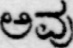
ಅವು
